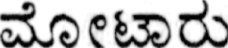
ಮೋಟಾರು
